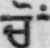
ਚੋਂ
